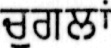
ਚੁਗਲਾਂ
